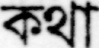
কথা
